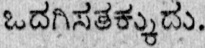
ಒದಗಿಸತಕ್ಕುದು.
